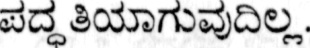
ಪದ್ಧತಿಯಾಗುವುದಿಲ್ಲ.
